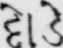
દોડે
